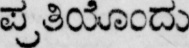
ಪ್ರತಿಯೊಂದು
